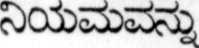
ನಿಯಮವನ್ನು
